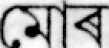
মোৰ
